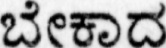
ಬೇಕಾದ
